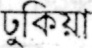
ঢুকিয়া
